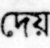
দেয়
